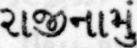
રાજીનામું
